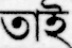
তাই
